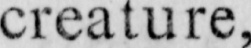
creature,
